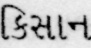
કિસાન
